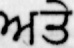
ਅਤੇ
